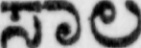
ಸಾಲ
